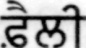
ਫ਼ੈਲੀ
